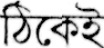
ঠিকেই
